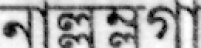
নাল্লম্লগা
